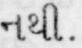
નથી.
